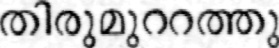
തിരുമുററത്തു
